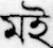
মই
